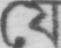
যে
